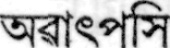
অৱাৎপসি
